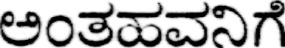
ಅಂತಹವನಿಗೆ
